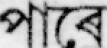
পাৰে
